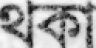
থকা
